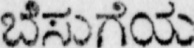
ಬೆಸುಗೆಯ
